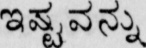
ಇಷ್ಟವನ್ನು
